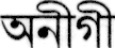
অনীগী
